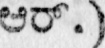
ಆರ್.)
